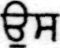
ਉਸ
